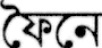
ফৈনে
